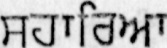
ਸਹਾਰਿਆ
